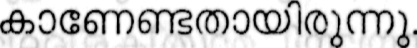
കാണേണ്ടതായിരുന്നു.
